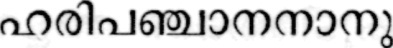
ഹരിപഞ്ചാനനാനു
